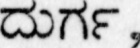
ದುರ್ಗ,
